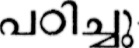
പഠിച്ചു
